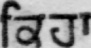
ਕਿਹਾ
